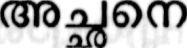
അച്ഛനെ
